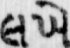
લખે
